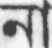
না
